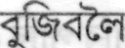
বুজিবলৈ
